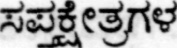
ಸಪ್ತಕ್ಷೇತ್ರಗಳ
